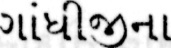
ગાંધીજીના
